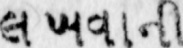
લખવાની
